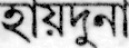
হায়দুনা
